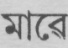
মাৱে
